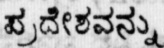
ಪ್ರದೇಶವನ್ನು
